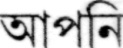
আপনি
